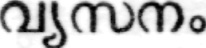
വ്യസനം
